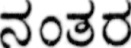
ನಂತರ
